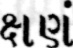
ક્ષણં
